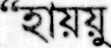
“হায়য়ু
